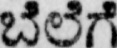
ಬೆಲೆಗೆ
